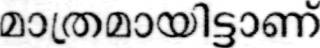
മാത്രമായിട്ടാണ്
